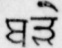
ਬੜੇ
